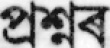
প্রশ্নৰ
